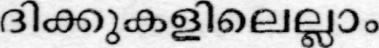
ദിക്കുകളിലെല്ലാം
